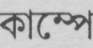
কাম্পে
